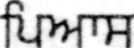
ਪਿਆਸ
